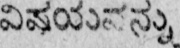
ವಿಷಯವನ್ನು
